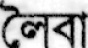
লৈবা
